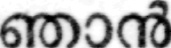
ഞാന്‍
